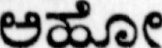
ಅಹೋ
